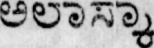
ಅಲಾಸ್ಕಾ
